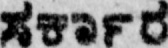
ಸರ್ಕಾರ
